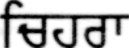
ਚਿਹਰਾ
